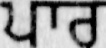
ਪਾਰ
